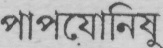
পাপযোনিষু
